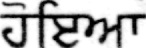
ਹੋਇਆ
